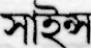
সাইন্স
